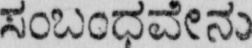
ಸಂಬಂಧವೇನು
